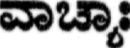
ವಾಚ್ಯಾಃ
